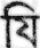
যি
